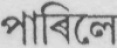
পাৰিলে
